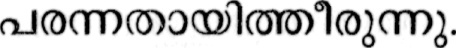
പരന്നതായിത്തീരുന്നു.
